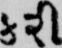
કરી
